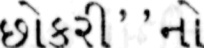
છોકરી"નો
